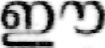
ഈ
